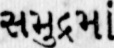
સમુદ્રમાં
